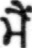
ਮੈਂ
